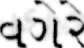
વગેરે
